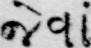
જેવાં
